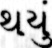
થયું
